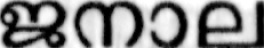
ജനാല
